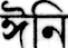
ঈনি
